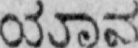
ಯಾವ
